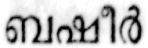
ബഷീര്‍
